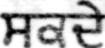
ਸਕਦੇ
